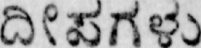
ದೀಪಗಳು
